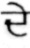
ਦੇ
